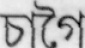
চাগৈ
